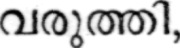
വരുത്തി,
